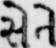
સેને
